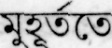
মুহূর্ততে
